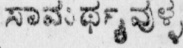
ಸಾಮರ್ಥ್ಯವುಳ್ಳ
